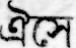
ঐসে
